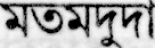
মতমদুদা
